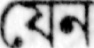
যেন
